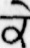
ਕੇ
